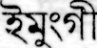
ইমুংগী
